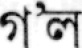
গ'ল
